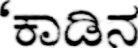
'ಕಾಡಿನ
